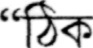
“ঠিক
